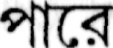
পারে
